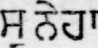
ਸੁਨੇਹਾ
